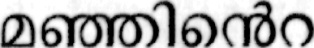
മഞ്ഞിന്റെ
